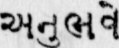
અનુભવે
